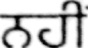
ਨਹੀਂ
